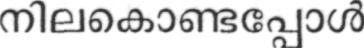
നിലകൊണ്ടപ്പോള്‍
